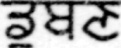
ਡੁਬਣ
